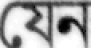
যেন
